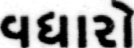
વધારો
